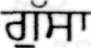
ਗੁੱਸਾ
